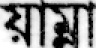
য়াম্না
